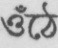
ওঁঠে
